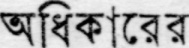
অধিকারের
